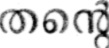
തന്റെ
